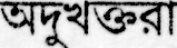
অদুখক্তরা
